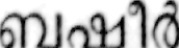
ബഷീര്‍
